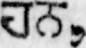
ਹਨ,
